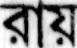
রায়
